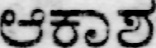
ಆಕಾಶ
